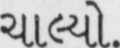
ચાલ્યો.
